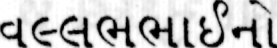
વલ્લભભાઈનો
